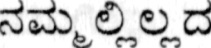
ನಮ್ಮಲ್ಲಿಲ್ಲದ
